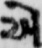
એ
